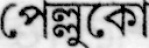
পেল্লুকো
